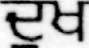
ਦੁਖ
